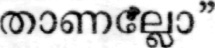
താണല്ലോ”
